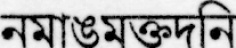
নমাঙমক্তদনি
